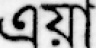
এয়া
